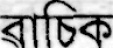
ৱাচিক
